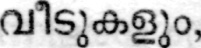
വീടുകളും,
